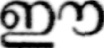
ഈ
